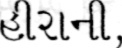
હીરાની,
